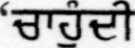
'ਚਾਹੁੰਦੀ
